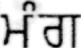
ਮੰਗ
